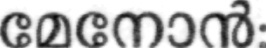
മേനോന്‍:
